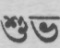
শুভ
